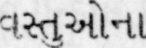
વસ્તુઓના
